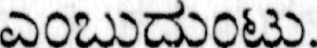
ಎಂಬುದುಂಟು.
